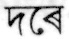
দৰে
